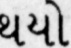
થયો
